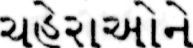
ચહેરાઓને
